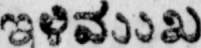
ಇಳಿಮುಖ
